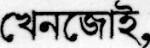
খেনজোই,
